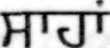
ਸਾਹਾਂ
